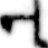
ન
